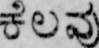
ಕೆಲವು
